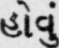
હોવું
